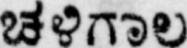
ಚಳಿಗಾಲ
